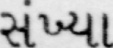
સંખ્યા
